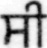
ਸੀ
